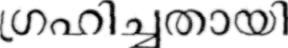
ഗ്രഹിച്ചതായി
